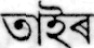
তাইৰ
